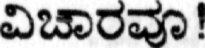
ವಿಚಾರವೂ!
